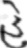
હે
